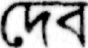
দেব
